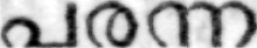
പരന്ന
